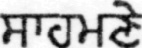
ਸਾਹਮਣੇ
